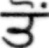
ਤੋਂ
